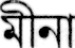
মীনা
